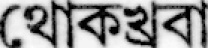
থোকখ্রবা
